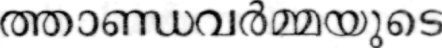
ത്താണ്ഡവര്‍മ്മയുടെ
